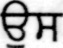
ਉਸ
